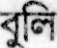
বুলি
